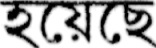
হয়েছে
